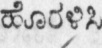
ಹೊರಳಿಸಿ
